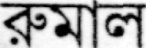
রুমাল
